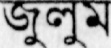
জুলুম
